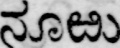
ನೂಱು
